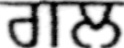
ਗਲ
